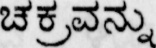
ಚಕ್ರವನ್ನು
